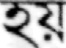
হয়
